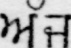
ਅੱਜ
